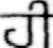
ਹੀ
